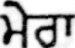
ਮੇਰਾ
